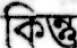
কিন্তু
